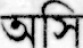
অসি
